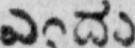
ಎಂದು
